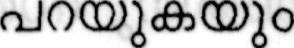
പറയുകയും
